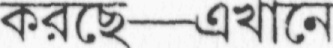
করছে–এখানে
